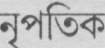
নৃপতিক
